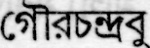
গৌরচন্দ্রবু
